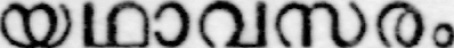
യഥാവസരം
